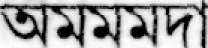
অমমমদা
